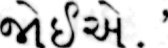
જોઈએ.'
